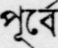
পূর্বে
